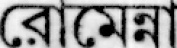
রোমেন্না
